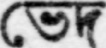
ভেদ
